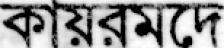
কায়রমদে
